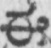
ಈ
